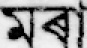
মৰা
